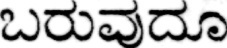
ಬರುವುದೂ
